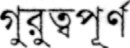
গুরুত্বপূর্ণ
